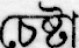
চেষ্টা
